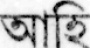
আহি
